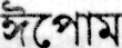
ঈপোম
